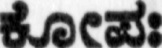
ಕೋಪಃ
